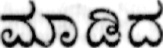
ಮಾಡಿದ
